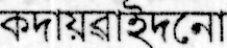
কদায়ৱাইদনো
